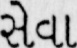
સેવા
